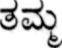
ತಮ್ಮ
